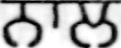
ਨਾਲ
